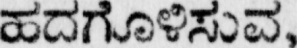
ಹದಗೊಳಿಸುವ,
